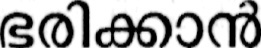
ഭരിക്കാന്‍
